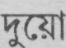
দুয়ো
